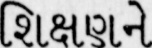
શિક્ષણને
